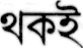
থকই
